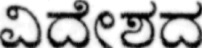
ವಿದೇಶದ
